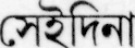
সেইদিনা
